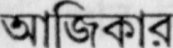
আজিকার
